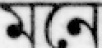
মনে
